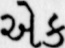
એક
